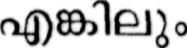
എങ്കിലും
